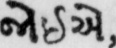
જોઈએ,
